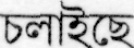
চলাইছে
